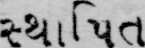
સ્થાપિત
